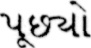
પૂછ્યો
